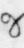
જ
